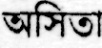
অসিতা
